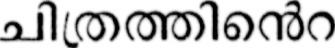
ചിത്രത്തിന്റെ
